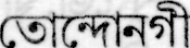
তোন্দোনগী
